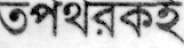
তপথরকই
